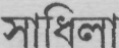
সাধিলা
